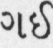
ગઈ
